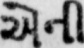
એની
